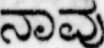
ನಾವು
